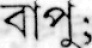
বাপু;
